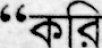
“করি
